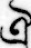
ঐ
